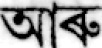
আৰু
